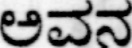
ಅವನ
